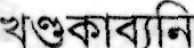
খণ্ডকাব্যনি
